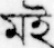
মই
